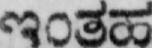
ಇಂತಹ
